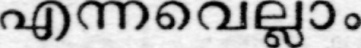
എന്നവെല്ലാം
